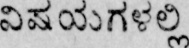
ವಿಷಯಗಳಲ್ಲಿ
